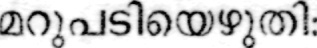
മറുപടിയെഴുതി:
